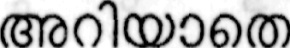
അറിയാതെ
